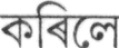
কৰিলে
